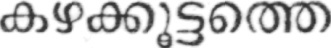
കഴക്കൂട്ടത്തെ
